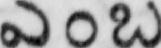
ಎಂಬ
